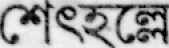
শেৎহল্লে
